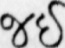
જઈ
